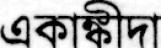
একাঙ্কীদা
